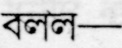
বলল–
